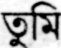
তুমি
